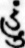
હું
